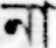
না
